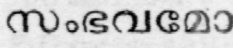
സംഭവമോ
